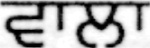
ਵਾਲਾ
